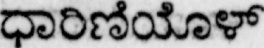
ಧಾರಿಣಿಯೊಳ್
